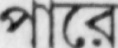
পারে
